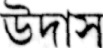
উদাস
